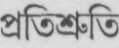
প্রতিশ্ৰুতি
